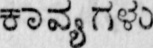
ಕಾವ್ಯಗಳು
